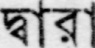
দ্বারা
